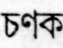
চণক
